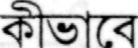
কীভাবে
